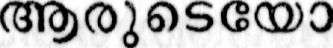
ആരുടെയോ
